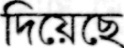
দিয়েছে
